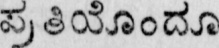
ಪ್ರತಿಯೊಂದೂ
